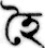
হৈ
